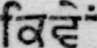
ਕਿਵੇਂ
